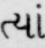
ત્યાં
